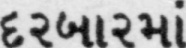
દરબારમાં
